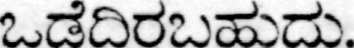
ಒಡೆದಿರಬಹುದು.
